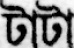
টাটা
